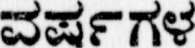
ವರ್ಷಗಳ
